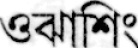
ওঝাশিং
